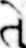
તે
